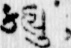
કહ્યું,
